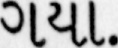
ગયા.
